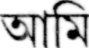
আমি
